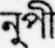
নুপী
